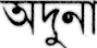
অদুনা
